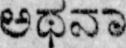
ಅಥವಾ
